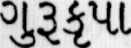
ગુરૂકૃપા
